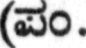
(ಪಂ.
